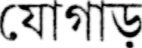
যোগাড়
